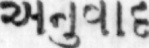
અનુવાદ
